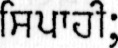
ਸਿਪਾਹੀ;
